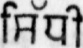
ਸਿੱਧੀ
